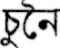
চুনৈ
